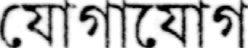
যোগাযোগ
